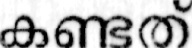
കണ്ടത്
